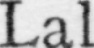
lal
